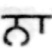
ਨਾ
